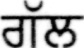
ਗੱਲ
